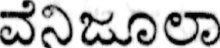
ವೆನಿಜೂಲಾ
